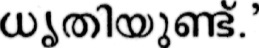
ധൃതിയുണ്ട്.’
